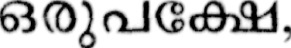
ഒരുപക്ഷേ,
